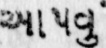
આપવું
